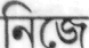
নিজে
